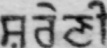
ਸ਼ਰੇਣੀ
